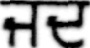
ਜਦ
